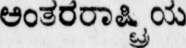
ಅಂತರರಾಷ್ಟ್ರೀಯ
